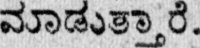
ಮಾಡುತ್ತಾರೆ.
